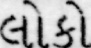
લોકો
